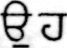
ਉਹ
